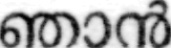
ഞാന്‍
